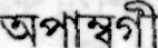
অপাম্বগী
